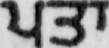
ਪਤਾ
